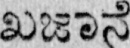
ಖಜಾನೆ
